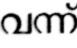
വന്ന്
